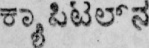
ಕ್ಯಾಪಿಟಲ್ ನ
